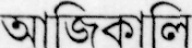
আজিকালি
